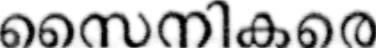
സൈനികരെ
